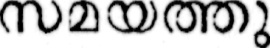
സമയത്തു
